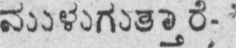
ಮುಳುಗುತ್ತಾರೆ.
